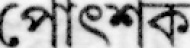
পোৎশক
